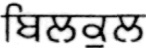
ਬਿਲਕੁਲ
